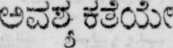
ಅವಶ್ಯಕತೆಯೇ
